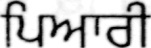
ਪਿਆਰੀ
